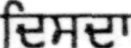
ਦਿਸਦਾ
